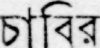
চাবির
